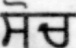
ਸੋਚ
